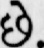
છે.
